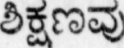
ಶಿಕ್ಷಣವು
